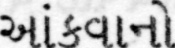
આંકવાનો
